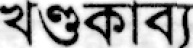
খণ্ডকাব্য
